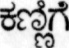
ಕಣ್ಣಿಗೆ
